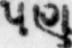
પણ
